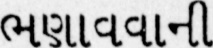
ભણાવવાની
